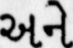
અને
